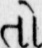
તો
